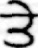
ਤੇ
